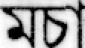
মচা
